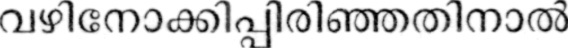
വഴിനോക്കിപ്പിരിഞ്ഞതിനാല്‍
